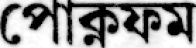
পোক্নফম
